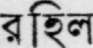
রহিল
